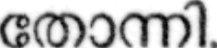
തോന്നി.
